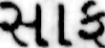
સાફ
